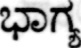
ಭಾಗ್ಯ
